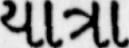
યાત્રા
